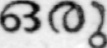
ഒരു
